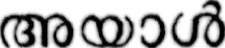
അയാള്‍
